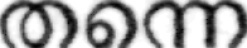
തന്നെ
